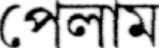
পেলাম
